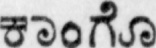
ಕಾಂಗೊ
